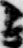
કે
